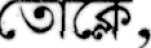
তোক্লে,
